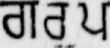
ਗਰੁਪ
